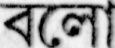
বলো
